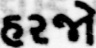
હરજો
